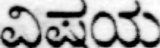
ವಿಷಯ
